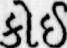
કોઈ
